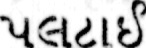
પલટાઈ
